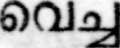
വെച്ച
